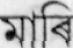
মাৰি
